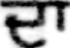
ਦਾ
